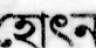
হোৎন
